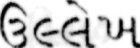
ઉલ્લેખ
